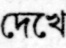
দেখে
